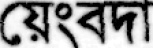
য়েংবদা
